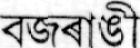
বজৰাঙী
